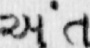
અંત
